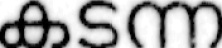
കടന്ന
